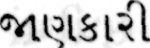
જાણકારી
